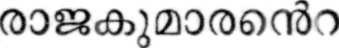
രാജകുമാരന്റെ
